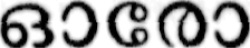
ഓരോ
